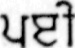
ਪਈ
